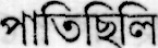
পাতিছিলি
